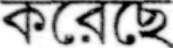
করেছে
